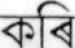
কৰি
